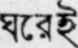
ঘরেই
